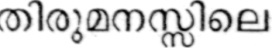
തിരുമനസ്സിലെ
